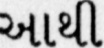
આથી
